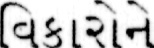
વિકારોને
